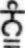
ਨੂੰ
